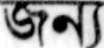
জন্য
